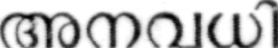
അനവധി
